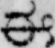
ಈ
